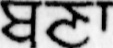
ਬਣਾ
